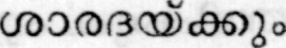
ശാരദയ്ക്കും
